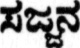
ಸಜ್ಜನ
